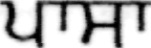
ਪਾਸਾ
